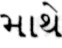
માથે
